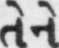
તેને
